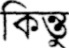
কিন্তু
